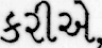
કરીએ,
